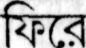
ফিরে
